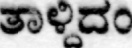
ತಾಳ್ದಿದಂ
